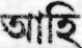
আহি
